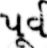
પૂર્વ
